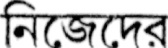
নিজেদের
